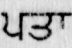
ਪਤਾ
